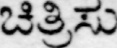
ಚಿತ್ರಿಸು
